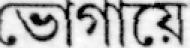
ভোগায়ে
